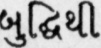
બુદ્ધિથી
